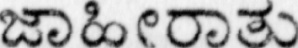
ಜಾಹೀರಾತು
